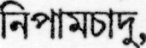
নিপামচাদু,
